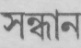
সন্ধান
